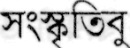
সংস্কৃতিবু
